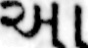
આ
